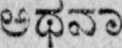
ಅಥವಾ
